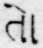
તો
